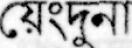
য়েংদুনা
